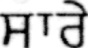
ਸਾਰੇ
